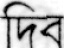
দিব
